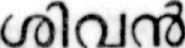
ശിവന്‍
